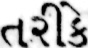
તરીકે
